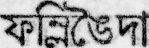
ফম্লিঙৈদা
